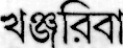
খঞ্জরিবা
